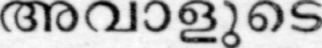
അവാളുടെ
